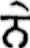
ਨੇ
